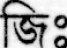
জিঃ
